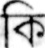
কি
